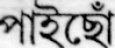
পাইছোঁ
